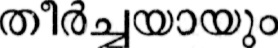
തീര്‍ച്ചയായും
